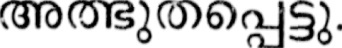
അത്ഭുതപ്പെട്ടു.
